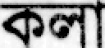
কলা
